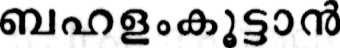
ബഹളംകൂട്ടാന്‍
